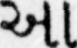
આ
